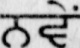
ਨਵੇਂ
